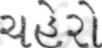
ચહેરો
